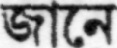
জানে
